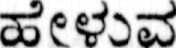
ಹೇಳುವ
